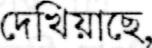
দেখিয়াছে,
